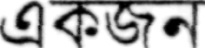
একজন
